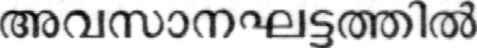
അവസാനഘട്ടത്തില്‍
